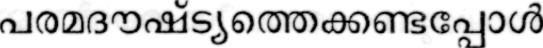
പരമദൌഷ്ട്യത്തെക്കണ്ടപ്പോള്‍
